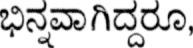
ಭಿನ್ನವಾಗಿದ್ದರೂ,
